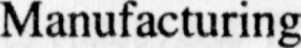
Manufacturing
